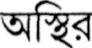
অস্থির
